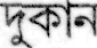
দুকান
